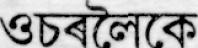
ওচৰলৈকে
